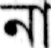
না
